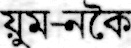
য়ুম-নকৈ
